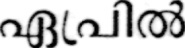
ഏപ്രില്‍
